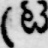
(ಟ
